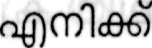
എനിക്ക്
